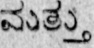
ಮತ್ತು
